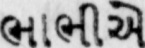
ભાભીએ
